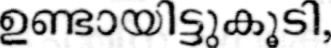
ഉണ്ടായിട്ടുകൂടി,
